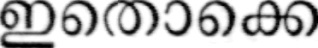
ഇതൊക്കെ
